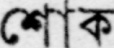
শোক
